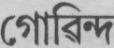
গোৱিন্দ
